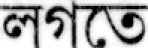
লগতে
